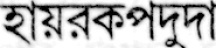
হায়রকপদুদা
